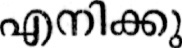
എനിക്കു
